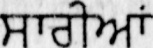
ਸਾਰੀਆ
